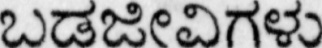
ಬಡಜೀವಿಗಳು
